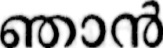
ഞാന്‍
